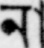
না
